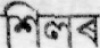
শিলৰ
